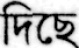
দিছে
